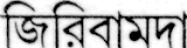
জিরিবামদা
